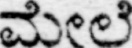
ಮೇಲೆ
